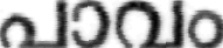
പാവം
